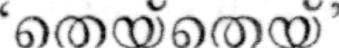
‘തെയ്തെയ്'
